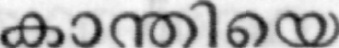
കാന്തിയെ
